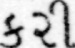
કરી
